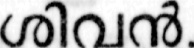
ശിവന്‍.
